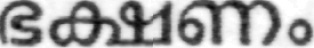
ഭക്ഷണം
